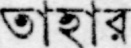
তাহার
